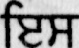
ਇਸ
